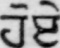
ਹੋਏ
